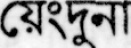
য়েংদুনা
